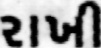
રાખી
